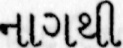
નાગથી
